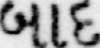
બાદ
